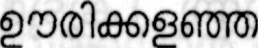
ഊരിക്കളഞ്ഞ
